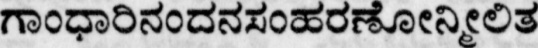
ಗಾಂಧಾರಿನಂದನಸಂಹರಣೋನ್ಮೀಲಿತ
